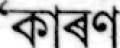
'কাৰণ
